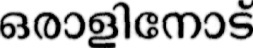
ഒരാളിനോട്
